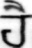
ਹੈ
